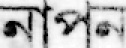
নাপন
